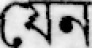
যেন
